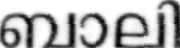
ബാലി
